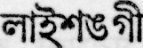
লাইশঙগী
